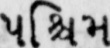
પશ્ચિમ
